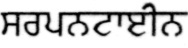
ਸਰਪਨਟਾਈਨ
